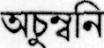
অচুম্বনি
